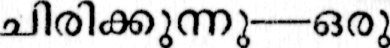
ചിരിക്കുന്നു-ഒരു
